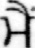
ਮੈਂ
